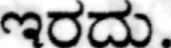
ಇರದು.
